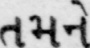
તમને
